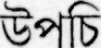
উপচি
